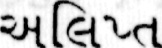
અલિપ્ત
